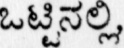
ಒಟ್ಟಿನಲ್ಲಿ,
